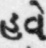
હવે
